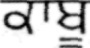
ਕਾਬੂ
